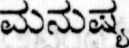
ಮನುಷ್ಯ
